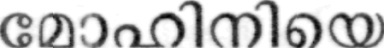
മോഹിനിയെ
